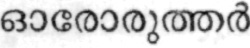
ഓരോരുത്തര്‍
